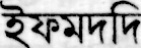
ইফমদদি
